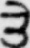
ਤੇ
